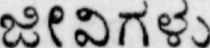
ಜೀವಿಗಳು
